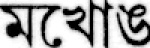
মখোঙ
